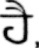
ਹੈ,
